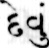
દેવું
